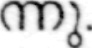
ന്നു.
